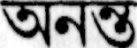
অনন্ত
